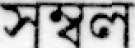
সম্বল
